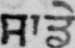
ਸਾਡੇ
